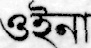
ওইনা
